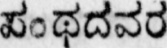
ಪಂಥದವರ
